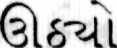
ઊઠ્યો
